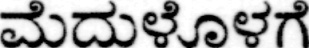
ಮೆದುಳೊಳಗೆ
